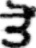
ਤੋਂ
